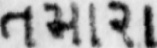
તમારા
